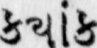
ક્યાંક
